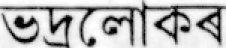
ভদ্রলোকৰ
